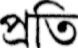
প্রতি
